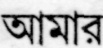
আমার
